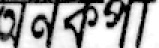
অনকপা
